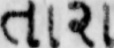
તારા
